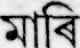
মাৰি
